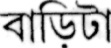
বাড়িটা
